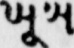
ખૂબ
